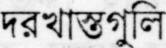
দরখাস্তগুলি
